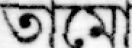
তামো
